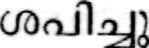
ശപിച്ചു
